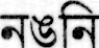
নঙনি
